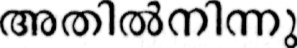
അതില്‍നിന്നു
